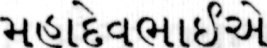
મહાદેવભાઈએ
